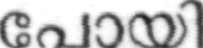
പോയി
